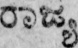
ರಾಜ್ಯ
